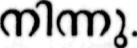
നിന്നു.
